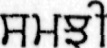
ਸਮਝੀ
